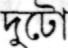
দুটো
